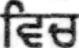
ਵਿਚ
